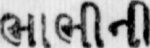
ભાભીની
